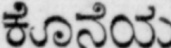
ಕೊನೆಯ
